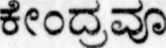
ಕೇಂದ್ರವೂ
